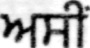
ਅਸੀਂ
